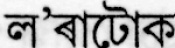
ল'ৰাটোক
